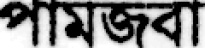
পামজবা
